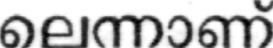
ലെന്നാണ്
